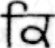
ਕਿ
